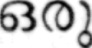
ഒരു
